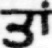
ਤਾਂ
